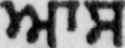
ਆਸ
